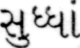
સુધ્ધાં
